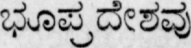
ಭೂಪ್ರದೇಶವು
